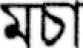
মচা
